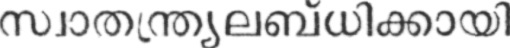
സ്വാതന്ത്ര്യലബ്ധിക്കായി
